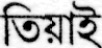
তিয়াই
